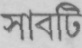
সাবটি
